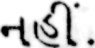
નહીં.
